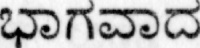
ಭಾಗವಾದ
